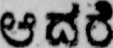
ಆದರೆ
